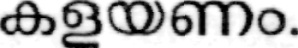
കളയണം.
